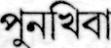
পুনখিবা
